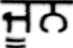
ਜੂਨ
